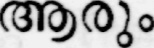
ആരും
